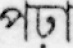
পঢ়া
